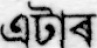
এটাৰ
